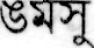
ঙমসু
